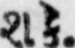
શકે.
